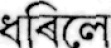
ধৰিলে
